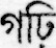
গঢ়ি
